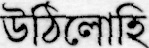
উঠিলোহি
